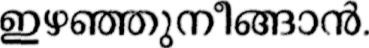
ഇഴഞ്ഞുനീങ്ങാന്‍.
